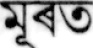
মূৰত
